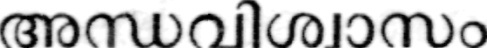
അന്ധവിശ്വാസം
